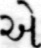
એ
